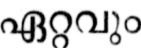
ഏറ്റവും
